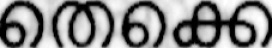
തെക്കെ
